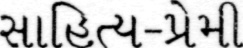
સાહિત્ય-પ્રેમી
